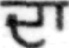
ਦਾ
